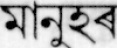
মানুহৰ
